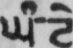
ਘੰਟੇ
